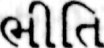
ભીતિ
